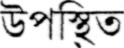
উপস্থিত
